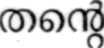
തന്റെ
